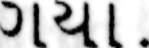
ગયા.
